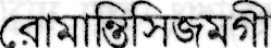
রোমান্তিসিজমগী
